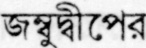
জম্বুদ্বীপের
